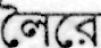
লৈরে
